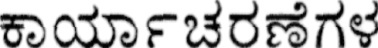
ಕಾರ್ಯಾಚರಣೆಗಳ
